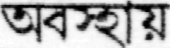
অবস্থায়
